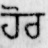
ਹੋਰ
